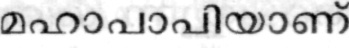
മഹാപാപിയാണ്
